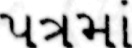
પત્રમાં
